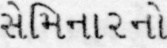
સેમિનારનો
